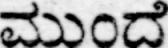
ಮುಂದೆ
